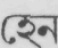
হেন
